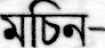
মচিন-
